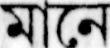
মানে
